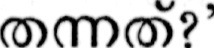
തന്നത്?’
